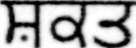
ਸ਼ਕਤ
